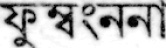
ফুম্বংননা
